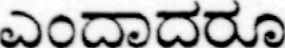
ಎಂದಾದರೂ
